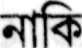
নাকি
